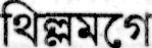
থিল্লমগে
